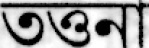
তত্তনা
